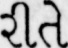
રીતે
